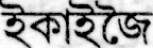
ইকাইজৈ
